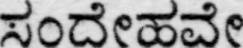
ಸಂದೇಹವೇ
